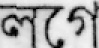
লগে
